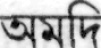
অমদি
